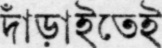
দাঁড়াইতেই
